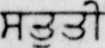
ਸਤੁਤੀ
